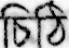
চিঠি
